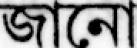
জানো
